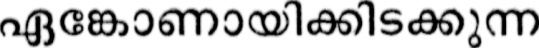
ഏങ്കോണായിക്കിടക്കുന്ന
